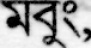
মবুং,
